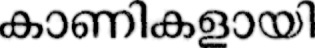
കാണികളായി
